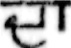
ਦਾ
